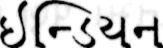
ઇન્ડિયન
